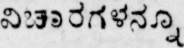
ವಿಚಾರಗಳನ್ನೂ
